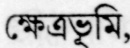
ক্ষেত্রভূমি,
